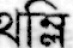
থম্লি
